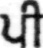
ਪੀ
